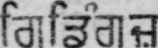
ਗਿਡਿੰਗਜ਼
